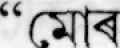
"মোৰ
